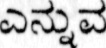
ಎನ್ನುವ
